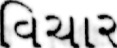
વિચાર
